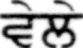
ਵੇਲੇ
